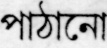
পাঠানো
